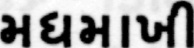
મધમાખી
